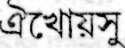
ঐখোয়সু
